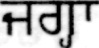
ਜਗ੍ਹਾ
